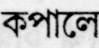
কপালে
